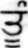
ਤੂੰ
